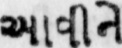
આવીને
